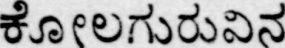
ಕೋಲಗುರುವಿನ
